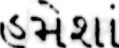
હમેશાં
